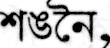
শঙনৈ,
